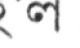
হ'ল
